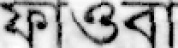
ফাওবা
